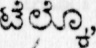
ಟೆಲ್ಕೊ,
